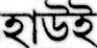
হাউই
